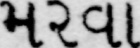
મરવા
